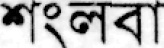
শংলবা
